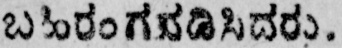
ಬಹಿರಂಗಪಡಿಸಿದರು.
